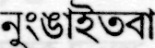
নুংঙাইতবা
